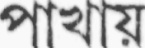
পাখায়
